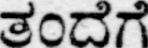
ತಂದೆಗೆ
